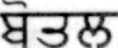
ਬੋਤਲ
